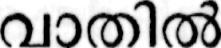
വാതില്‍
